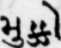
મુક્કો
